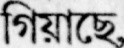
গিয়াছে,
